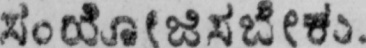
ಸಂಯೋಜಿಸಬೇಕು.
